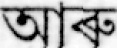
আৰু
